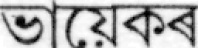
ভায়েকৰ
